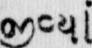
જીવ્યાં
